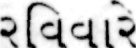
રવિવારે
